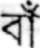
বাঁ
